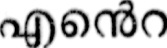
എന്റെ
